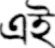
এই
